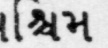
પશ્ચિમ
